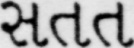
સતત
